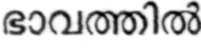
ഭാവത്തില്‍
